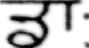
ਡਾ:
